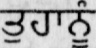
ਤੁਹਾਨੂੰ
